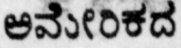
ಅಮೇರಿಕದ
